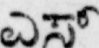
ಎಸ್
